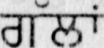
ਗੱਲਾਂ
